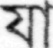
যা
